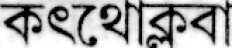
কৎথোক্লবা
